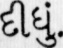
દીધું.
